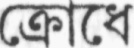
ক্রোধে
